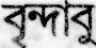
বৃন্দাবু
